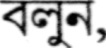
বলুন,
